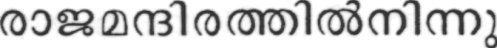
രാജമന്ദിരത്തില്‍നിന്നു
